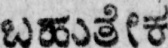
ಬಹುತೇಕ
